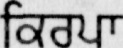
ਕਿਰਪਾ
